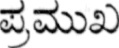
ಪ್ರಮುಖ
